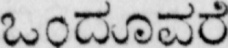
ಒಂದೂವರೆ
